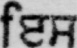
ਇਸ
